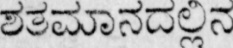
ಶತಮಾನದಲ್ಲಿನ
